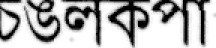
চঙলকপা
